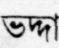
ভদ্দা
